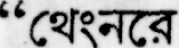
“থেংনরে
